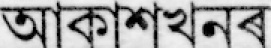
আকাশখনৰ
